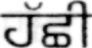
ਹੱਛੀ
